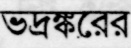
ভদ্রঙ্করের
